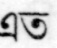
এত
